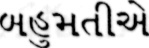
બહુમતીએ
